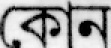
কোন
